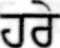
ਹਰੇ
